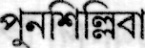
পুনশিল্লিবা
